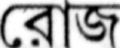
রোজ
